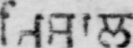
ਮਿਸਾਲ
